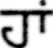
ਹਾਂ
